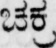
ಚಕ್ರ
